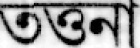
তত্তনা
